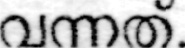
വന്നത്.
